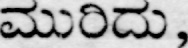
ಮುರಿದು,
